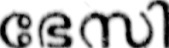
ഭേസി
